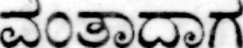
ವಂತಾದಾಗ
